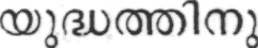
യുദ്ധത്തിനു
